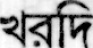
খরদি
